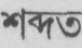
শব্দত
